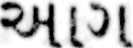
આગ
